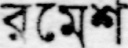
রমেশ
